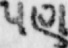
પણ
